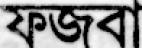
ফজবা
